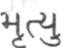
મૃત્યુ
